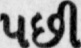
પછી
